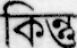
কিন্তু
